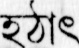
হঠাৎ
